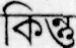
কিন্তু
